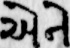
એને
